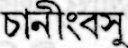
চানীংবসু
